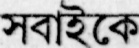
সবাইকে
